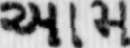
આમ
